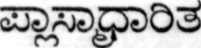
ಪ್ಲಾಸ್ಮಾಧಾರಿತ
